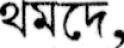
থমদে,
